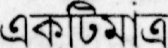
একটিমাত্র
